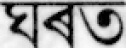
ঘৰত
